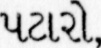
પટારો,
